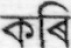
কৰি
